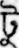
টু
